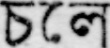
চলে
